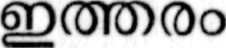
ഇത്തരം
